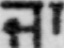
ਜਾ
